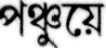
পঞ্চুয়ে
